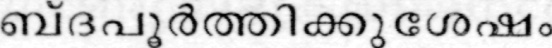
ബ്ദപൂര്‍ത്തിക്കുശേഷം
